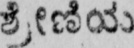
ಶ್ರೇಣಿಯ
